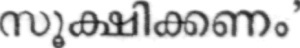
സൂക്ഷിക്കണം’
